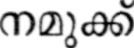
നമുക്ക്
